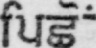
ਪਿਛੋਂ
